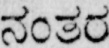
ನಂತರ
